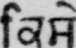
ਕਿਸੇ
